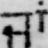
ਜਾਂ
